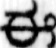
ಈ
